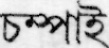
চম্পাই
